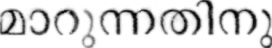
മാറുന്നതിനു
